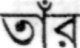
তাঁর
